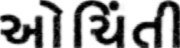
ઓચિંતી
